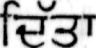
ਦਿੱਤਾ
